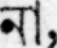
না,
